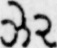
ઝેર
